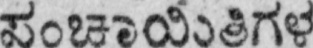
ಪಂಚಾಯಿತಿಗಳ
